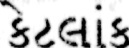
કેટલાંક
